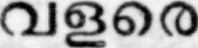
വളരെ
